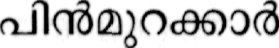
പിന്‍മുറക്കാര്‍
